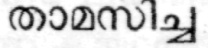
താമസിച്ച
